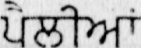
ਪੈਲੀਆਂ
